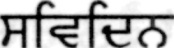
ਸਵਿਦਿਨ
